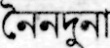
নৈনদুনা
